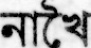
নাখৈ
